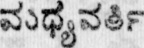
ಮಧ್ಯವರ್ತಿ
